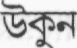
উকুন
